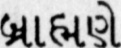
બ્રાહ્મણે
